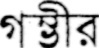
গম্ভীর
